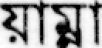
য়াম্না
